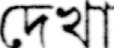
দেখা
